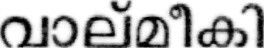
വാല്മീകി
